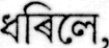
ধৰিলে,
